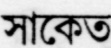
সাকেত
